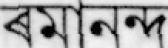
ৰমানন্দ
